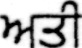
ਅਤੀ
